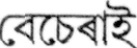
বেচেৰাই
